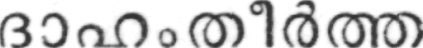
ദാഹംതീര്‍ത്ത
